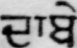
ਦਾਬੇ
